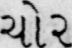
ચોર
